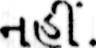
નહીં.
